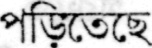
পড়িতেছে
